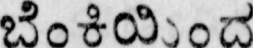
ಬೆಂಕಿಯಿಂದ
